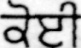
ਕੋਈ
